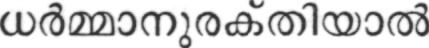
ധര്‍മ്മാനുരക്തിയാല്‍
